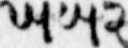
ખબર
